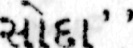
સોદા"
